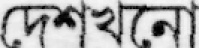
দেশখনো
